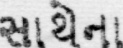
સાથેના
